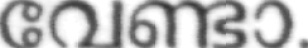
വേണ്ടാ.
